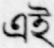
এই
